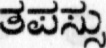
ತಪಸ್ಸು
